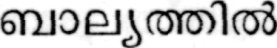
ബാല്യത്തില്‍
